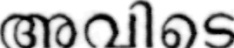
അവിടെ
